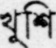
খুশি
